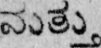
ಮತ್ತು
